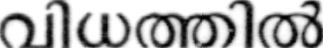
വിധത്തില്‍
